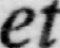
et
